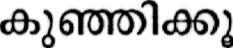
കുഞ്ഞിക്കൂ
